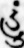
હું
